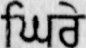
ਘਿਰੇ
